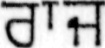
ਰਾਜ
